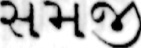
સમજી
